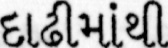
દાઢીમાંથી
